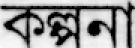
কল্পনা
